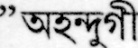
অহন্দুগী
